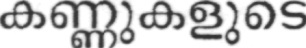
കണ്ണുകളുടെ
